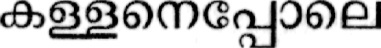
കള്ളനെപ്പോലെ
